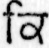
ਕਿ
